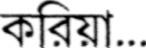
করিয়া...
